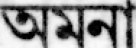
অমনা
